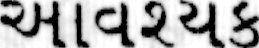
આવશ્યક
